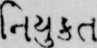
નિયુક્ત
